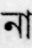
না
